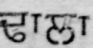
ਢਾਲਾ
